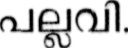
പല്ലവി.
